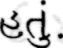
હતું.
